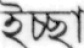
ইচ্ছা
